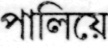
পালিয়ে
